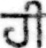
ਹੀ
